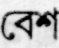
বেশ
